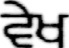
ਵੇਖ
